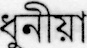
ধুনীয়া
